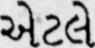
એટલે
